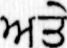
ਅਤੇ
